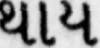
થાય
